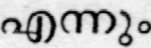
എന്നും
